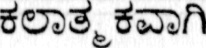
ಕಲಾತ್ಮಕವಾಗಿ
